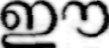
ഈ
